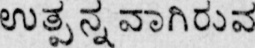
ಉತ್ಪನ್ನವಾಗಿರುವ
